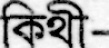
কিথী
